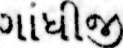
ગાંધીજી
